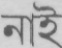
নাই
